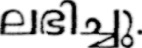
ലഭിച്ചു.
